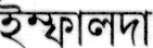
ইম্ফালদা
